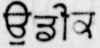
ਉਡੀਕ
